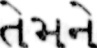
તેમને
